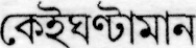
কেইঘণ্টামান
